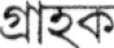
গ্রাহক
